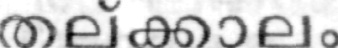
തല്ക്കാലം
